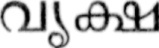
വൃക്ഷ
